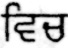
ਵਿਚ
